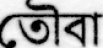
তৌবা
